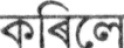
কৰিলে
